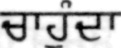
ਚਾਹੁੰਦਾ
